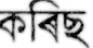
কৰিছ
